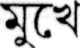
মুখে
